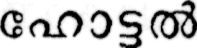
ഹോട്ടല്‍
